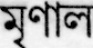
মৃণাল
